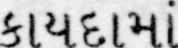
કાયદામાં
